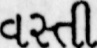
વસ્તી
